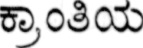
ಕ್ರಾಂತಿಯ
